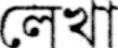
লেখা
